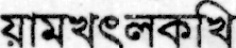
য়ামখৎলকখি
